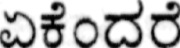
ಏಕೆಂದರೆ
